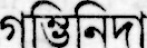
গম্ভিনিদা
